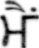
ਮੈਂ
